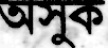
অসুক
